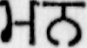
ਮਨ
